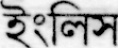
ইংলিস
